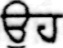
ਉਹ
